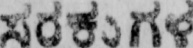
ಸರಕುಗಳ
